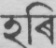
হৰি
